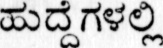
ಹುದ್ದೆಗಳಲ್ಲಿ
